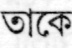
তাকে
